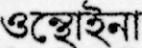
ওন্থোইনা
